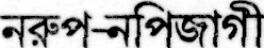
নরুপ-নপিজাগী
